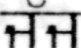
ਜੱਜ
